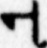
ન
